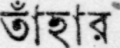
তাঁহার
